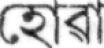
হোৱা
